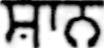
ਸ਼ਾਨ
